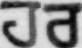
ਹਰ
